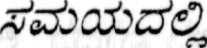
ಸಮಯದಲ್ಲಿ
